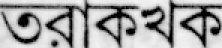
তরাকখক
